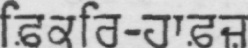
ਫ਼ਿਕਰਿ-ਹਾਫ਼ਜ਼
